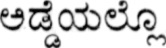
ಅಡ್ಡೆಯಲ್ಲೊ
